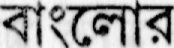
বাংলোর
